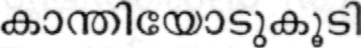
കാന്തിയോടുകൂടി
